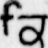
ਕਿ
